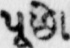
પૂછો
